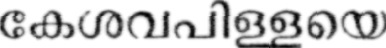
കേശവപിള്ളയെ
